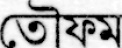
তৌফম
